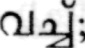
വച്ച്;
